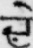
ਦੇ
